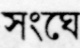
সংঘে
